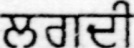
ਲਗਦੀ
